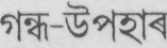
গন্ধ-উপহাৰ
